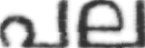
പല
